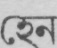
হেন
